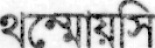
থম্মোয়সি
